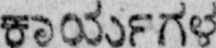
ಕಾರ್ಯಗಳ
